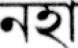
নহা
